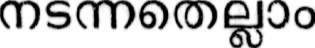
നടന്നതെല്ലാം
